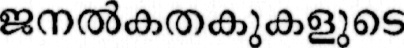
ജനല്‍കതകുകളുടെ
